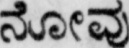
ನೋವು
